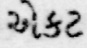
એકટ
